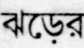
ঝড়ের
